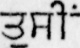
ਤੁਸੀਂ
